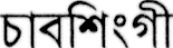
চাবশিংগী
